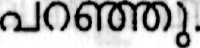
പറഞ്ഞു.
